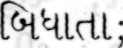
બિધાતા;
